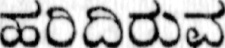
ಹರಿದಿರುವ
